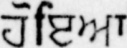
ਹੋਇਆ
